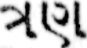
ત્રણ
